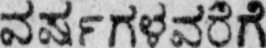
ವರ್ಷಗಳವರೆಗೆ
